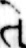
તે
